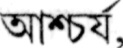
আশ্চর্য,
